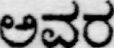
ಅವರ
